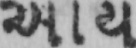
આય
